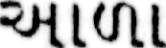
આળા
